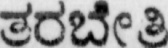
ತರಬೇತಿ
